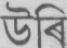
উৰি
